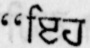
''ਇਹ
